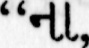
"ના,
